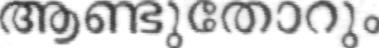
ആണ്ടുതോറും
